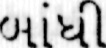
બાંધી
